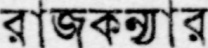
রাজকন্যার
